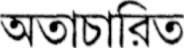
অতাচারিত
